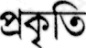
প্রকৃতি
